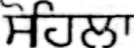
ਸੋਹਿਲਾ
